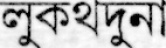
লুকথদুনা
